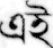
এই
